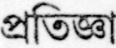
প্রতিজ্ঞা
